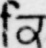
ਕਿ
